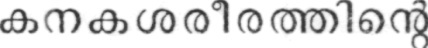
കനകശരീരത്തിന്റെ
